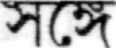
সঙ্গে
